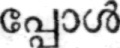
പ്പോള്‍
